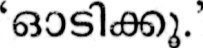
‘ഓടിക്കൂ.’
